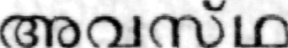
അവസ്ഥ
